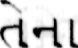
તેના
